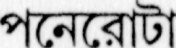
পনেরোটা
